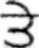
ਤੇ
